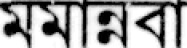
মমান্নবা
